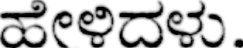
ಹೇಳಿದಳು.
